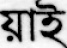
য়াই
